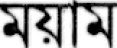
ময়াম
